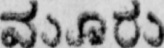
ಮೂರು
